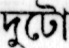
দুটো
